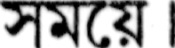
সময়ে।
